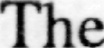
The
